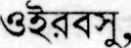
ওইরবসু,
